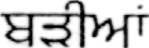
ਬੜੀਆਂ
